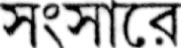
সংসারে
